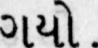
ગયો.
